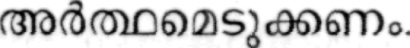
അര്‍ത്ഥമെടുക്കണം.
